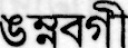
ঙম্নবগী
